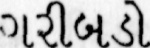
ગરીબડો
